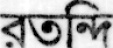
রতন্দি
